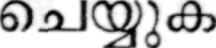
ചെയ്യുക
